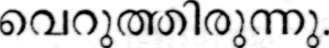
വെറുത്തിരുന്നു.
